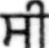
ਸੀ
